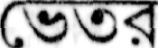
ভেতর
